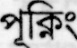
পূক্নিং
